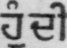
ਹੁੰਦੀ
